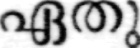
ഏതു
